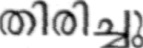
തിരിച്ചു
